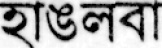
হাঙলবা
